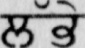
ਲੱਭੇ
